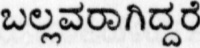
ಬಲ್ಲವರಾಗಿದ್ದರೆ
